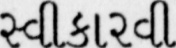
સ્વીકારવી
